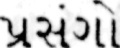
પ્રસંગો
